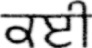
ਕਈ
